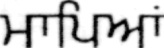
ਮਾਪਿਆਂ
